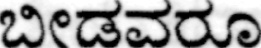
ಬೀಡವರೂ
